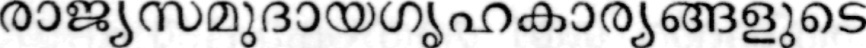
രാജ്യസമുദായഗൃഹകാര്യങ്ങളുടെ
